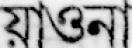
য়াওনা
